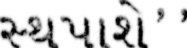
સ્થપાશે"
